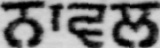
ਨਾਵਲ
